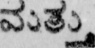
ಮತ್ತು
